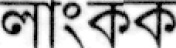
লাংকক
